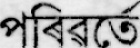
পৰিৱর্তে
